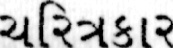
ચરિત્રકાર
